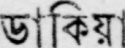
ডাকিয়া
